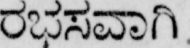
ರಭಸವಾಗಿ
